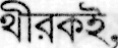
থীরকই,
